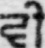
ਵੀ
